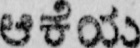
ಆಕೆಯ
